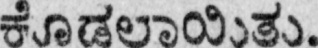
ಕೊಡಲಾಯಿತು.
